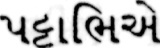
પટ્ટાભિએ
